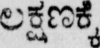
ಲಕ್ಷಣಕ್ಕೆ
